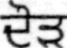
ਦੌੜ
